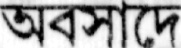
অবসাদে
